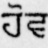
ਹੋਵ
